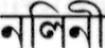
নলিনী
